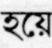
হয়ে
